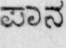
ಪಾನ
